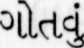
ગોતવું
